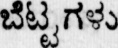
ಬೆಟ್ಟಗಳು
